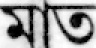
মাত
